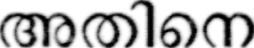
അതിനെ
